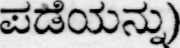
ಪಡೆಯನ್ನು)
